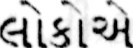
લોકોએ
